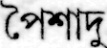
পৈশাদু
